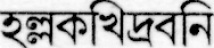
হল্লকখিদ্রবনি
